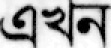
এখন
